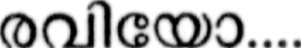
രവിയോ....
